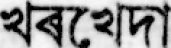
খৰখেদা
